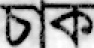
চাক
